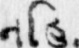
નહિ.
